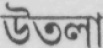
উতলা
